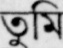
তুমি
